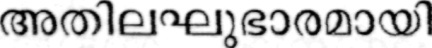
അതിലഘുഭാരമായി
